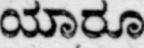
ಯಾರೂ
